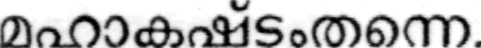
മഹാകഷ്ടംതന്നെ.
